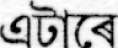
এটাৰে
